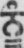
ਨੂੰ
